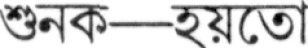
শুনক-হয়তো
